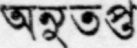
অনুতপ্ত
